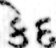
કેદ
